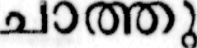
ചാത്തു
